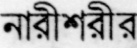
নারীশরীর
